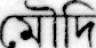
মৌদি
